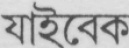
যাইবেক
